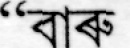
"বাৰু
